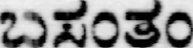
ಬಸಂತಂ
